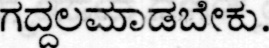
ಗದ್ದಲಮಾಡಬೇಕು.
